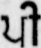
ਪੀ
